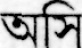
অসি
